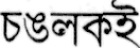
চঙলকই
